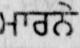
ਮਾਰਨੇ
